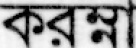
করম্না
